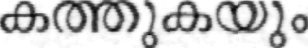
കത്തുകയും
